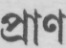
প্ৰাণ
